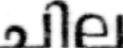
ചില
